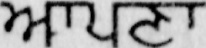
ਆਪਣਾ
